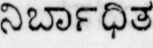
ನಿರ್ಬಾಧಿತ
